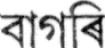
বাগৰি
